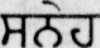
ਸਨੇਹ
